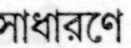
সাধারণে
